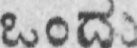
ಒಂದು
